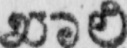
ಖಾಲಿ
